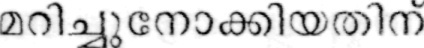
മറിച്ചുനോക്കിയതിന്
